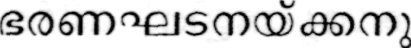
ഭരണഘടനയ്ക്കനു
